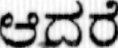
ಆದರೆ
